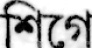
শিগে
